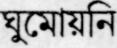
ঘুমোয়নি
